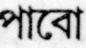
পাবো
